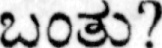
ಬಂತು?
